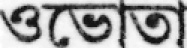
ওভোতা
